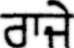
ਰਾਜੇ
